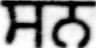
ਸਨ
